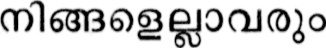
നിങ്ങളെല്ലാവരും
